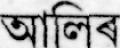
আলিৰ
